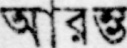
আরম্ভ
